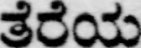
ತೆರೆಯ
